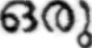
ഒരു
